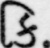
કિ.
